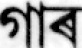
গাৰ
